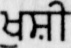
ਖੁਸ਼ੀ
